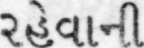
રહેવાની
